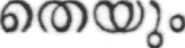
തെയും
